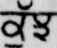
ਕੁੱਝ
